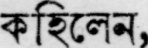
কহিলেন,
